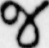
જ
